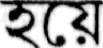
হয়ে
